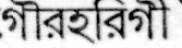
গৌরহরিগী
